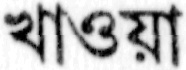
খাওয়া
